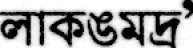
লাকঙমদ্র’
